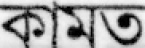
কামত
